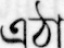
এঠা
